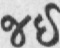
જઈ
